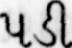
પડી
